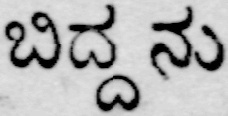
ಬಿದ್ದನು
